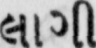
લાગી
